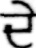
ਦੇ
